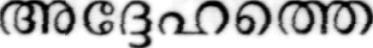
അദ്ദേഹത്തെ
